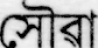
সৌৱা
